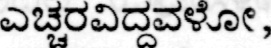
ಎಚ್ಚರವಿದ್ದವಳೋ,
